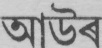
আউৰ
